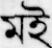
মই
